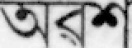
অবশ
